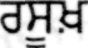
ਰਸੂਖ਼
